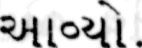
આવ્યો.
